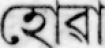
হোৱা
